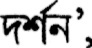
দর্শন',
